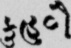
કુહવૈ
